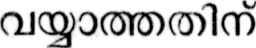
വയ്യാത്തതിന്
